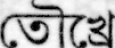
তৌখ্রে
